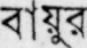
বায়ুর
